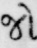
જો
